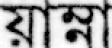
য়াম্না
